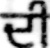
ਦੀ
